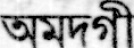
অমদগী
